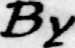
By
